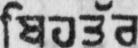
ਬਿਹਤੱਰ
